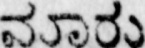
ಮಾರು
